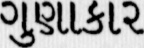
ગુણાકાર
